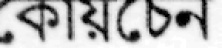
কোয়চেন
